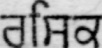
ਰਸਿਕ
